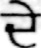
ਦੇ
